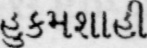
હુકમશાહી
